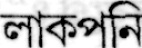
লাকপনি
